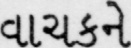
વાચકને
